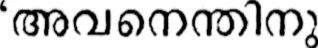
‘അവനെന്തിനു
